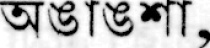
অঙাঙশা,
